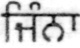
ਜਿੰਨਾ
